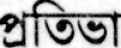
প্রতিভা
